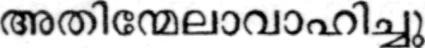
അതിന്മേലാവാഹിച്ചു
